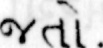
જતો.
